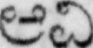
ಆವಿ
